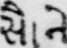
સૌને
